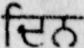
ਦਿਨ
